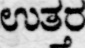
ಉತ್ತರ
